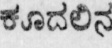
ಕೂದಲಿನ
